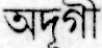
অদূগী
